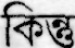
কিন্তু
